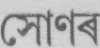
সোণৰ
